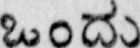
ಒಂದು
